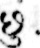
છું.
